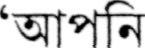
‘আপনি
